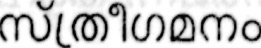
സ്ത്രീഗമനം
